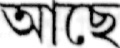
আছে
